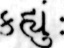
કહ્યું:
